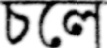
চলে
